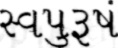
સ્વપુરૂષં
